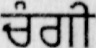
ਚੰਗੀ
